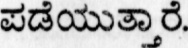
ಪಡೆಯುತ್ತಾರೆ.
